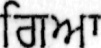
ਗਿਆ
